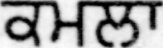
ਕਮਲਾ
